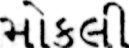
મોકલી
